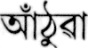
আঁঠুৱা
